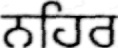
ਨਹਿਰ
